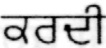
ਕਰਦੀ
